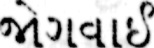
જોગવાઈ
